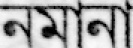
নমানা
